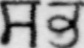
ਸਭ
